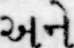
અને
